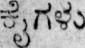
ಕೈಗಳು
